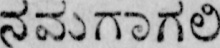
ನಮಗಾಗಲಿ
